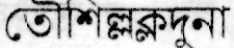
তৌশিল্লক্লদুনা
